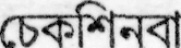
চেকশিনবা
